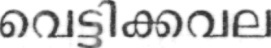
വെട്ടിക്കവല
